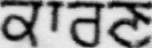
ਕਾਰਣ
